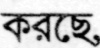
করছে,
